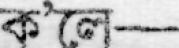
ক'লে-
